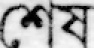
শেষ
